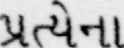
પ્રત્યેના
